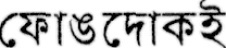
ফোঙদোকই
